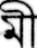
মী
